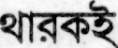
থারকই
